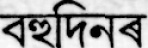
বহুদিনৰ
